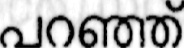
പറഞ്ഞ്
